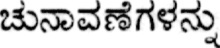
ಚುನಾವಣೆಗಳನ್ನು
